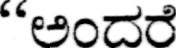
"ಅಂದರೆ
